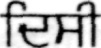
ਦਿਸੀ
